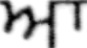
ਆ
